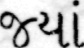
જ્યાં
